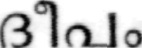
ദീപം
